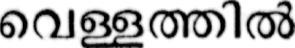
വെള്ളത്തില്‍
